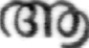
ആ
